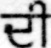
ਦੀ
